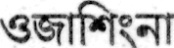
ওজাশিংনা
